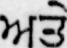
ਅਤੇ
